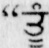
''ਤੂੰ
